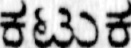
ಕಟುಕ
